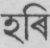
হৰি
